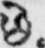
છે.
